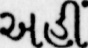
અહીં
